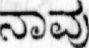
ನಾವು
